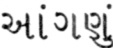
આંગણું
